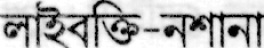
লাইবক্তি-নশানা
